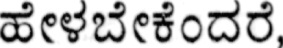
ಹೇಳಬೇಕೆಂದರೆ,
